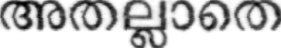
അതല്ലാതെ
